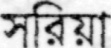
সরিয়া
